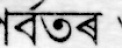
পর্বতৰ
